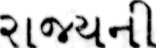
રાજ્યની
